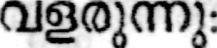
വളരുന്നു:
